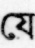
যে
